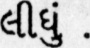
લીધું.
